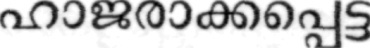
ഹാജരാക്കപ്പെട്ട
